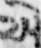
એ
